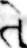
તે
